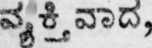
ವ್ಯಕ್ತಿವಾದ,
